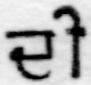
ਦੀ
